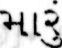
મારું
